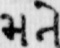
મને
